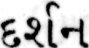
દર્શન
